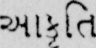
આકૃતિ
